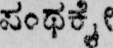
ಪಂಥಕ್ಕೇ
